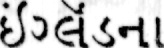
ઇંગ્લૅંડના
